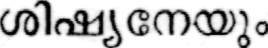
ശിഷ്യനേയും
